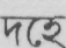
দহে
